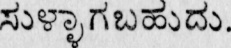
ಸುಳ್ಳಾಗಬಹುದು.
